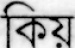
কিয়
